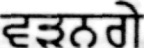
ਵੜਨਗੇ
